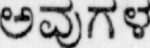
ಅವುಗಳ
